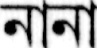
নানা
